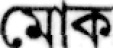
মোক
